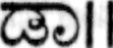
ಡಾ||
